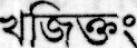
খজিক্তং
